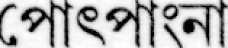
পোৎপাংনা
